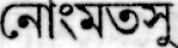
নোংমতসু
